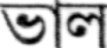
ভাল
